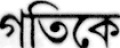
গতিকে
